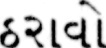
ઠરાવો
